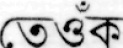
তেওঁক
